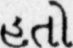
હતો
